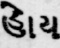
હોય
